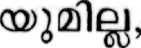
യുമില്ല,
